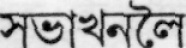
সভাখনলৈ
